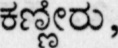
ಕಣ್ಣೀರು,
